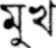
মুখ
